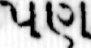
પણ
